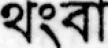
থংবা
